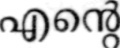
എന്റെ
